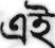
এই
